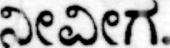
ನೀವೀಗ.
